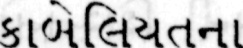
કાબેલિયતના
